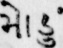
મોડું
